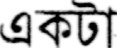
একটা
